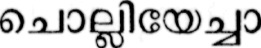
ചൊല്ലിയേച്ചാ
